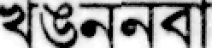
খঙননবা
